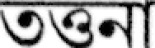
তত্তনা
